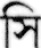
সি
